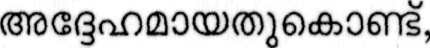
അദ്ദേഹമായതുകൊണ്ട്,
